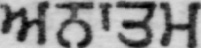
ਅਨਾਤਮ
